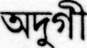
অদুগী
